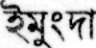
ইমুংদা
